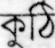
কুঠি
